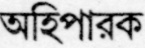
অহিপারক
